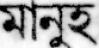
মানুহ
